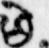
છે.
